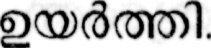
ഉയര്‍ത്തി.
